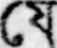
যে
